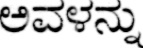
ಅವಳನ್ನು
